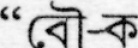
"বৌ-ক
